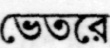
ভেতরে
